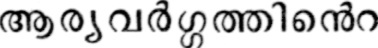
ആര്യവര്‍ഗ്ഗത്തിന്റെ
